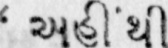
'અહીંથી
